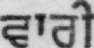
ਵਾਰੀ
